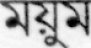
ময়ুম
